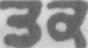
ਤਕ
